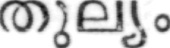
തുല്യം
